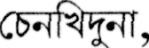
চেনখিদুনা,
